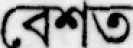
বেশত
